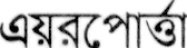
এয়রপোর্ত্তা
